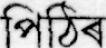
পিঠিৰ
